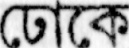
ঢোকে
